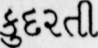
કુદરતી
